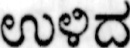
ಉಳಿದ
